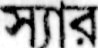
স্যার
